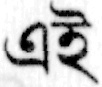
এই
